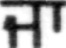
ਜਾ
